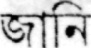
জানি
